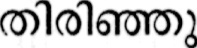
തിരിഞ്ഞു
